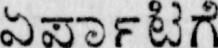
ಏರ್ಪಾಟಿಗೆ
